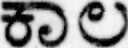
ಕಾಲ
